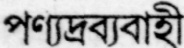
পণ্যদ্রব্যবাহী
